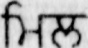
ਮਿਲ
